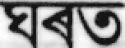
ঘৰত
